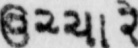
ઉચ્ચારે
